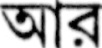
আর
